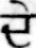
ਦੇ
